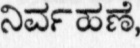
ನಿರ್ವಹಣೆ,
